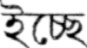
ইচ্ছে
